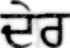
ਦੇਰ
